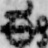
ಈ
